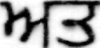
ਅਤ
